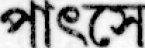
পাৎসে
